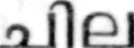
ചില
